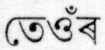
তেওঁৰ
